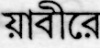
য়াবীরে
